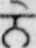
ਨੇ
